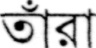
তাঁরা
